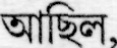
আছিল,
